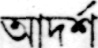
আদর্শ
